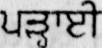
ਪੜ੍ਹਾਈ
